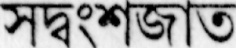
সদ্বংশজাত
